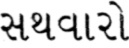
સથવારો
